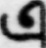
এ
